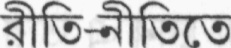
রীতি-নীতিতে
